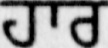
ਹਾਰ
